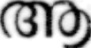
ആ
